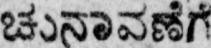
ಚುನಾವಣೆಗೆ
